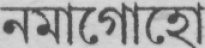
নমাগোহো
